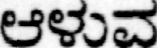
ಆಳುವ
